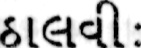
ઠાલવીઃ
